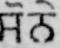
ਸੋਨੇ
